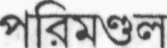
পরিমণ্ডল
